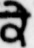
ਕੇ
